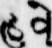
હવે
